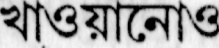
খাওয়ানোও
